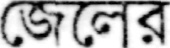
জেলের
